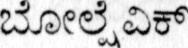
ಬೋಲ್ಷೆವಿಕ್
